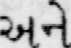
અને
